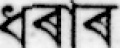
ধৰাৰ
